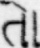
તો
